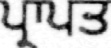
ਪ੍ਰਾਪਤ
